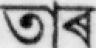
তাৰ
